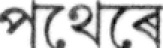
পথেৰে
